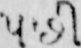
પછી
